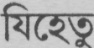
যিহেতু
